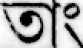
তাং
